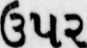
ઉપર
